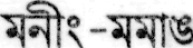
মনীং-মমাঙ
